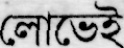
লোভেই
